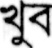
খুব
